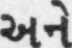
અને
